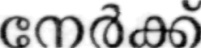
നേര്‍ക്ക്
